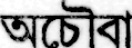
অচৌবা
